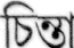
চিন্তা
